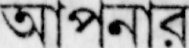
আপনার
